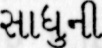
સાધુની
